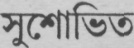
সুশোভিত
